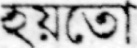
হয়তো
